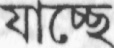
যাচ্ছে
